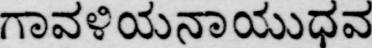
ಗಾವಳಿಯನಾಯುಧವ
